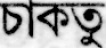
চাকতু
